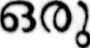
ഒരു
